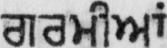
ਗਰਮੀਆਂ
